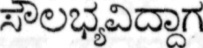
ಸೌಲಭ್ಯವಿದ್ದಾಗ
